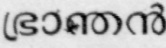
ഭ്രാന്തന്‍
